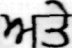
ਅਤੇ
